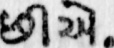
છીએ.
